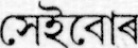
সেইবোৰ
